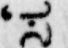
‘ಸ
